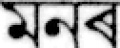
মনৰ
